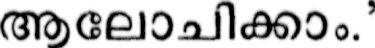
ആലോചിക്കാം.’
